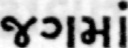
જગમાં
